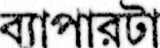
ব্যাপারটা
